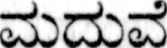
ಮದುವೆ
